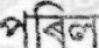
পৰিল
